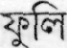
ফুলি
